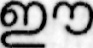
ഈ
